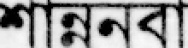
শান্ননবা
